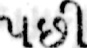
પછી
